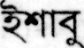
ইশাবু
